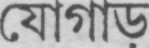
যোগাড়
